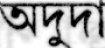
অদুদা
